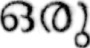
ഒരു
